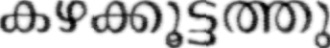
കഴക്കൂട്ടത്തു
